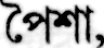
পৈশা,
